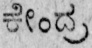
ಕೇಂದ್ರ
